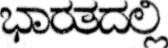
ಭಾರತದಲ್ಲಿ
